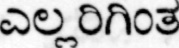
ಎಲ್ಲರಿಗಿಂತ
